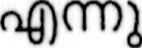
എന്നു
